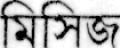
মিসিজ
